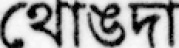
থোঙদা
